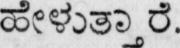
ಹೇಳುತ್ತಾರೆ.
